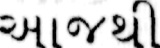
આજથી
